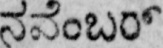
ನವೆಂಬರ್
